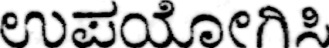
ಉಪಯೋಗಿಸಿ
